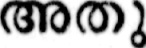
അതു
